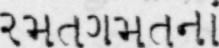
રમતગમતનાં
